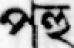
পহু
